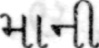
માની
